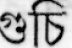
গুচি
